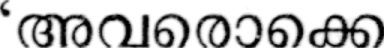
‘അവരൊക്കെ
